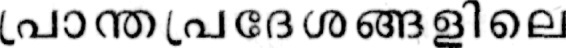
പ്രാന്തപ്രദേശങ്ങളിലെ
